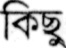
কিছু
